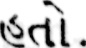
હતો.
